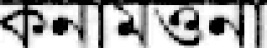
কনামত্তনা
